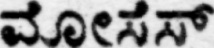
ಮೋಸೆಸ್
